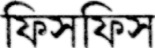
ফিসফিস
